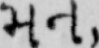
મન,
